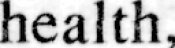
health,
